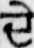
ਦੇ
